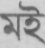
মই
